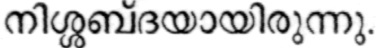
നിശ്ശബ്ദയായിരുന്നു.
